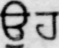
ਉਹ
